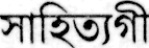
সাহিত্যগী
